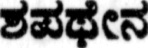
ಶಪಥೇನ
